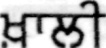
ਖ਼ਾਲੀ
